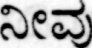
ನೀವು
